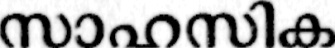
സാഹസിക
